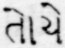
તોયે
